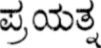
ಪ್ರಯತ್ನ
